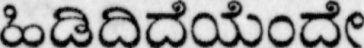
ಹಿಡಿದಿದೆಯೆಂದೇ
